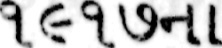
૧૯૧૭ના
